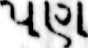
પણ
